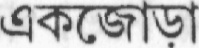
একজোড়া
